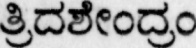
ತ್ರಿದಶೇಂದ್ರಂ
